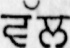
ਵੱਲ
